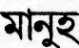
মানুহ
